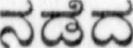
ನಡೆದ
